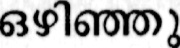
ഒഴിഞ്ഞു
